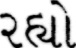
રહ્યો
